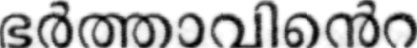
ഭര്‍ത്താവിന്റെ
